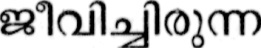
ജീവിച്ചിരുന്ന
